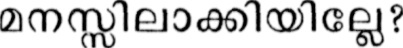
മനസ്സിലാക്കിയില്ലേ?
